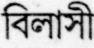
বিলাসী
